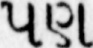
પણ
